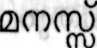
മനസ്സ്
